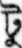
টু
